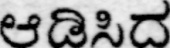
ಆಡಿಸಿದ
